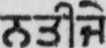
ਨਤੀਜੇ
